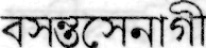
বসন্তসেনাগী
